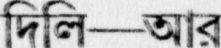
দিলি-আর
